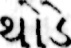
થોડે
